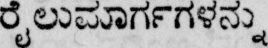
ರೈಲುಮಾರ್ಗಗಳನ್ನು
